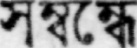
সম্বন্ধে
